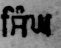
ਸਿੰਘ
